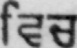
ਵਿਚ
